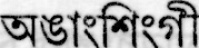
অঙাংশিংগী
